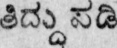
ತಿದ್ದುಪಡಿ
